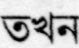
তখন
